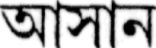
আসান
